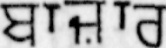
ਬਾਜ਼ਾਰ
